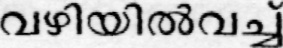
വഴിയില്‍വച്ച്
